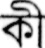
কী
